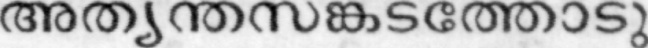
അത്യന്തസങ്കടത്തോടു
